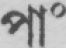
পা
